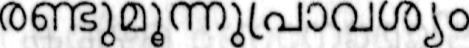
രണ്ടുമൂന്നുപ്രാവശ്യം
